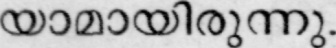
യാമായിരുന്നു.
